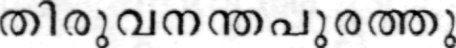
തിരുവനന്തപുരത്തു
